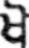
ਖੋ
